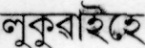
লুকুৱাইহে
